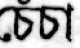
চেঁচা
